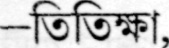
-তিতিক্ষা,
